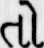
તો
